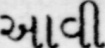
આવી
